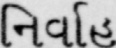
નિર્વાહ
